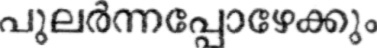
പുലര്‍ന്നപ്പോഴേക്കും
